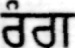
ਰੰਗ
